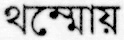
থম্মোয়
